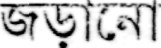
জড়ানো
